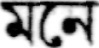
মনে
